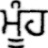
ਮੂੰਹ
